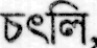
চৎলি,
